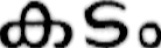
കടം
